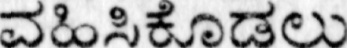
ವಹಿಸಿಕೊಡಲು
